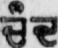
ਚੰਦ
